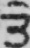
ਤੇ
